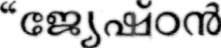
“ജ്യേഷ്ഠന്‍
